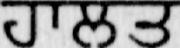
ਹਾਲਤ
